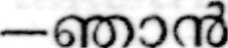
-ഞാന്‍
